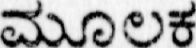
ಮೂಲಕ
